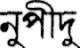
নুপীদু
